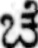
ಚೆ
